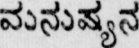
ಮನುಷ್ಯನ
